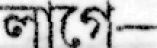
লাগে-
